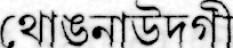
থোঙনাউদগী
